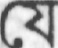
যে
